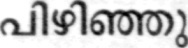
പിഴിഞ്ഞു
